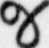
જ
